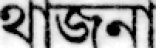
থাজনা
